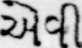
એવી
